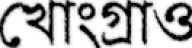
খোংগ্রাও
